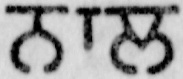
ਨਾਲ
